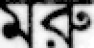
মরু
